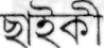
ছাইকী
